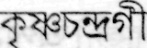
কৃষ্ণচন্দ্রগী
